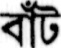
বাঁট
